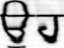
ਉਹ
